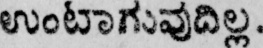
ಉಂಟಾಗುವುದಿಲ್ಲ.
